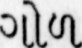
ગોળ
